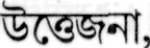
উত্তেজনা,
